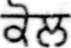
ਕੋਲ
